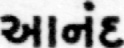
આનંદ
